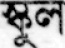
স্কুল
